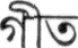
গীত
